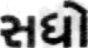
સધો
